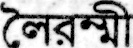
লৈরম্মী
